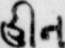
હીન
